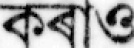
কৰাও
